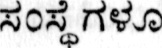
ಸಂಸ್ಥೆಗಳೂ
